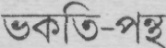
ভকতি-পন্থ
